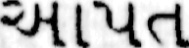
આપત
